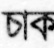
চাক
